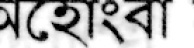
অহোংবা
